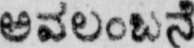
ಅವಲಂಬನೆ
